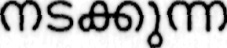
നടക്കുന്ന
